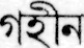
গহীন
